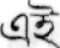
এই
